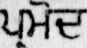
ਪ੍ਰਮੋਦ
